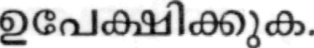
ഉപേക്ഷിക്കുക.
